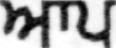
ਆਪ
